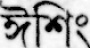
ঈশিং
